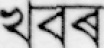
খবৰ
